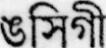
ঙসিগী
